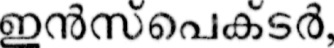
ഇന്‍സ്പെക്ടര്‍,
